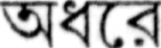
অধরে
